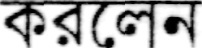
করলেন
